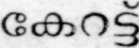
കേറട്ട്
